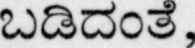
ಬಡಿದಂತೆ,
